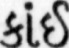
કાંઈ
